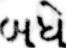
બધે
